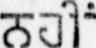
ਨਹੀਂ
